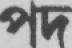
পদ
